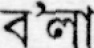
ব'লা
